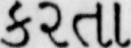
કરતા
